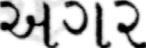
અગર
